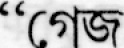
"গেজ
